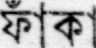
ফাঁকা
